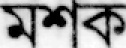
মশক
